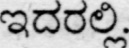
ಇದರಲ್ಲಿ.
